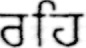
ਰਹਿ
